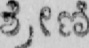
ಶ್ರೇಣಿ
